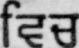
ਵਿਚ
